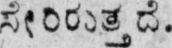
ಸೇರಿರುತ್ತದೆ.
